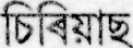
চিৰিয়াছ
